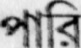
পারি
